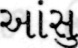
આંસુ
